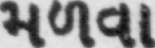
મળવા
